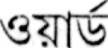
ওয়ার্ড
